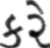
કરે
